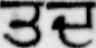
ਤਦ
